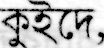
কুইদে,
